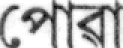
পোৱা
